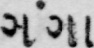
ગંગા
